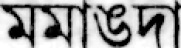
মমাঙদা
